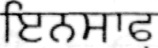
ਇਨਸਾਫ਼
